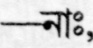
–নাঃ,
